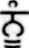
ਨੂੰ
